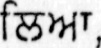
ਲਿਆ,
